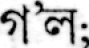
গ'ল;
